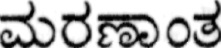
ಮರಣಾಂತ
